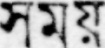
সময়
